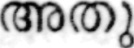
അതു
